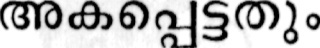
അകപ്പെട്ടതും
